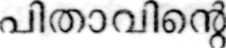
പിതാവിന്റെ
